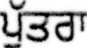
ਪੁੱਤਰਾ
